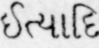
ઈત્યાદિ
